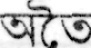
অতৈ
